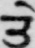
ਤੇ
